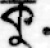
কু.
